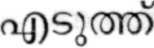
എടുത്ത്
